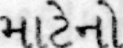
માટેનો
